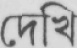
দেখি
